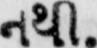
નથી.
